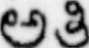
ಅತಿ
